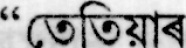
"তেতিয়াৰ
